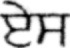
ਏਸ
